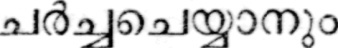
ചര്‍ച്ചചെയ്യാനും
